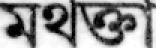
মথক্তা
